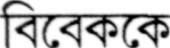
বিবেককে
